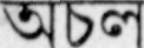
অচল
